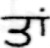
ਤਾਂ
